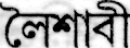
লৈশাবী
